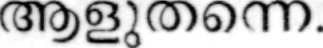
ആളുതന്നെ.
